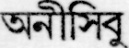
অনীসিবু
